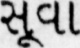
સૂવા
